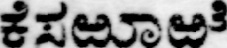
ಕೆಸಱೂಱೆ
